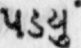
પડ્યું
